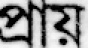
প্রায়
